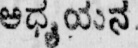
ಅಧ್ಯಯನ.
